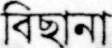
বিছানা
